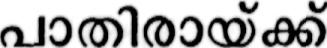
പാതിരായ്ക്ക്
